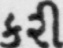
કરી
